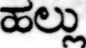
ಹಲ್ಲು
